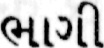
ભાગી
